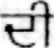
ਦੀ
